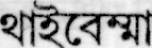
থাইবেম্মা
